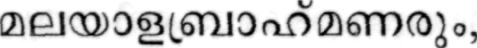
മലയാളബ്രാഹ്മണരും,
